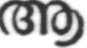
ആ
